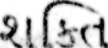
શક્તિ
